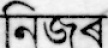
নিজৰ
